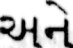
અને
